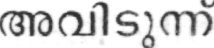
അവിടുന്ന്
